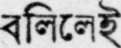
বলিলেই
